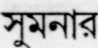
সুমনার
